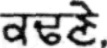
ਕਢਣੇ,
